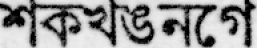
শকখঙনগে
